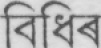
বিধিৰ
